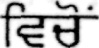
ਵਿਚੋਂ
